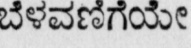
ಬೆಳವಣಿಗೆಯೇ
